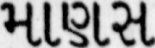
માણસ
